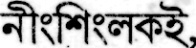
নীংশিংলকই,
